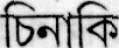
চিনাকি
